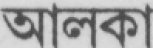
আলকা
